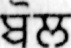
ਬੋਲ
